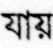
যায়
